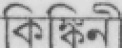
কিঙ্কিনী
